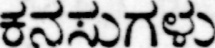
ಕನಸುಗಳು
